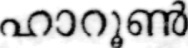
ഹാറൂണ്‍
